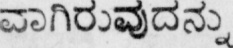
ವಾಗಿರುವುದನ್ನು
